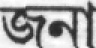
জনা
